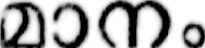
മാനം
